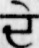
ਦੇ
